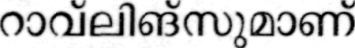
റാവ്ലിങ്സുമാണ്
